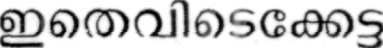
ഇതെവിടെക്കേട്ട
